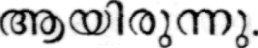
ആയിരുന്നു.
